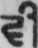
ਵੀ
